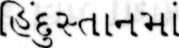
હિંદુસ્તાનમાં
